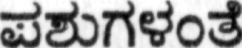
ಪಶುಗಳಂತೆ
